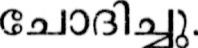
ചോദിച്ചു.
